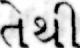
તેથી
